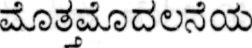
ಮೊತ್ತಮೊದಲನೆಯ
